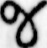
જ
